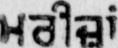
ਮਰੀਜ਼ਾਂ
